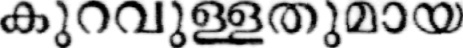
കുറവുള്ളതുമായ
